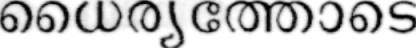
ധൈര്യത്തോടെ
